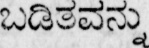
ಬಡಿತವನ್ನು
